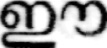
ഈ
